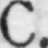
C.
